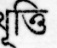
খূত্তি
